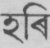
হৰি
